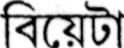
বিয়েটা
